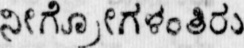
ನೀಗ್ರೋಗಳಂತಿರು
